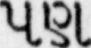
પણ
